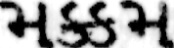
મક્કમ
